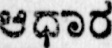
ಆಧಾರ
